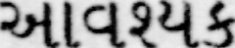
આવશ્યક
